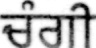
ਚੰਗੀ
